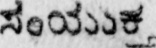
ಸಂಯುಕ್ತ
